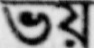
ভয়
